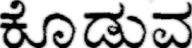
ಕೊಡುವ
